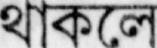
থাকলে
